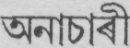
অনাচাৰী
